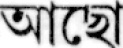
আছো
